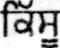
ਕਿੱਸੂ
